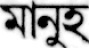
মানুহ
